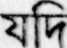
যদি
